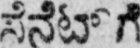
ಸೆನೆಟ್ಗೆ
